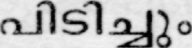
പിടിച്ചും
